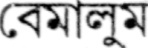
বেমালুম
